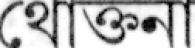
থোক্তনা
